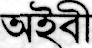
অইবী
